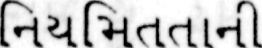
નિયમિતતાની
